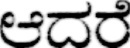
ಆದರೆ
